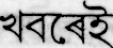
খবৰেই
